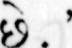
છે.'
